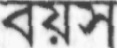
বয়স
